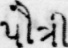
પૌત્રી
